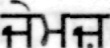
ਜੇਮਜ਼
